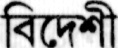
বিদেশী
